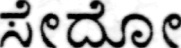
ಸೇದೋ
